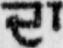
ਦਾ
